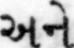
અને
